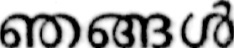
ഞങ്ങള്‍
